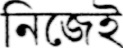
নিজেই
